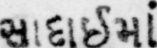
સાદાઈમાં
